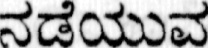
ನಡೆಯುವ
